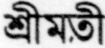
শ্রীমতী
